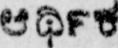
ಆರ್ಥಿಕ
